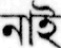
নাই
